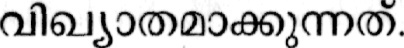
വിഖ്യാതമാക്കുന്നത്.
